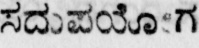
ಸದುಪಯೋಗ
